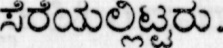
ಸೆರೆಯಲ್ಲಿಟ್ಟರು.
